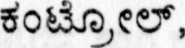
ಕಂಟ್ರೋಲ್,
